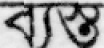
ব্যস্ত
